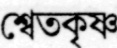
শ্বেতকৃষ্ণ
